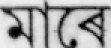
মাৰে
